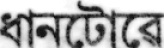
ধানটোৱে
